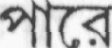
পারে
